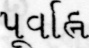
પૂર્વાહ્ન
